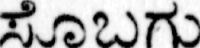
ಸೊಬಗು
